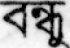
বন্ধু
